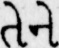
તેને
